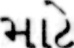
માટે
